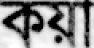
কয়া
